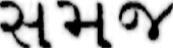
સમજ
